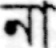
না
